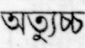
অত্যুচ্চ
